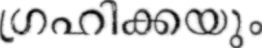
ഗ്രഹിക്കയും
